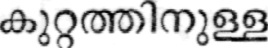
കുറ്റത്തിനുള്ള
